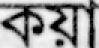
কয়া
